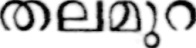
തലമുറ
